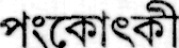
পংকোৎকী
